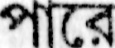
পারে
